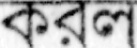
করল
